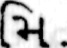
મિ.
